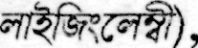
লাইজিংলেম্বী),
